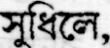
সুধিলে,
